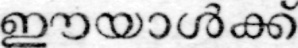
ഈയാള്‍ക്ക്
